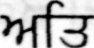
ਅਤਿ
